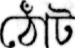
ঠোঁট
